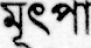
মূৎপা
